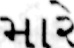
મારે
